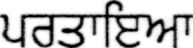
ਪਰਤਾਇਆ
